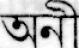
অনী
